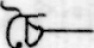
চৈ-
